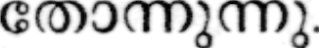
തോന്നുന്നു.
